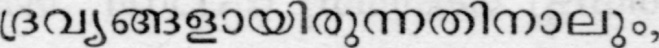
ദ്രവ്യങ്ങളായിരുന്നതിനാലും,
